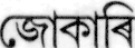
জোকাৰি
